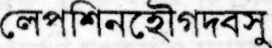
লেপশিনহৌগদবসু
